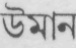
উমান
